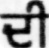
ਦੀ
